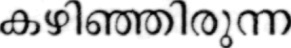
കഴിഞ്ഞിരുന്ന
